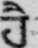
ਹੈ
